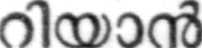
റിയാന്‍
